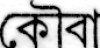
কৌবা
